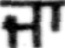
ਜਾ
